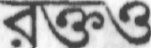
রক্তও
